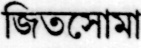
জিতসোমা
